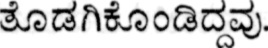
ತೊಡಗಿಕೊಂಡಿದ್ದವು.
